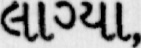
લાગ્યા,
